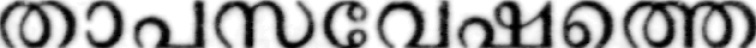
താപസവേഷത്തെ
